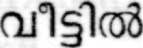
വീട്ടില്‍
